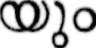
യും
